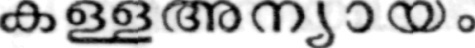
കള്ളഅന്യായം
